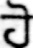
ਹੋ
